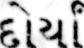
દોર્યાં
